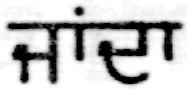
ਜਾਂਦਾ
